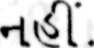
નહીં.
